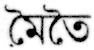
মৈতৈ
